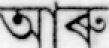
আৰু
